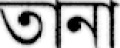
তানা
